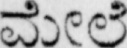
ಮೇಲೆ
